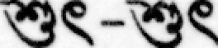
শুৎ-শুৎ
